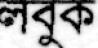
লবুক
